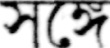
সঙ্গে
